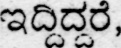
ಇದ್ದಿದ್ದರೆ,
